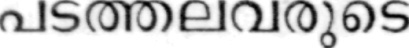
പടത്തലവരുടെ
